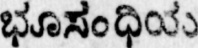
ಭೂಸಂಧಿಯ
